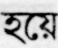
হয়ে
